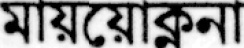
মায়য়োক্ননা
